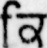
ਕਿ
